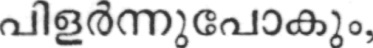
പിളര്‍ന്നുപോകും,
